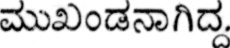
ಮುಖಂಡನಾಗಿದ್ದ.
